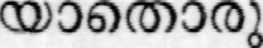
യാതൊരു
